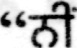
''ਨੀਂ
